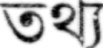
তথ্য
